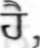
ਹੈ,
